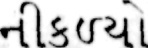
નીક્ળયો
